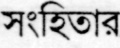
সংহিতার
